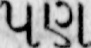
પણ
